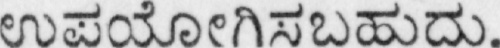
ಉಪಯೋಗಿಸಬಹುದು.
